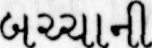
બચ્ચાની
